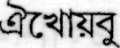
ঐখোয়বু
